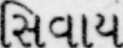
સિવાય
